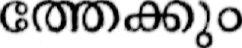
ത്തേക്കും
